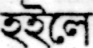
হইলে
